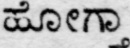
ಹೋಗ್ತಾ
